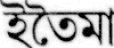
ইতৈমা
